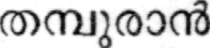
തമ്പുരാന്‍
